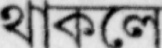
থাকলে
